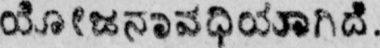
ಯೋಜನಾವಧಿಯಾಗಿದೆ.
